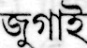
জুগাই
